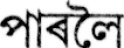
পাৰলৈ
